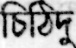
চিঠিদু
